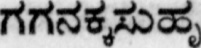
ಗಗನಕ್ಕಸುಹೃ
